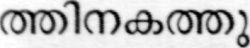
ത്തിനകത്തു
